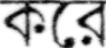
করে
